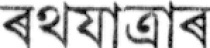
ৰথযাত্রাৰ
